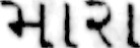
મારા
